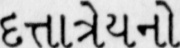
દત્તાત્રેયનો
